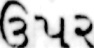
ઉપર
